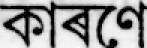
কাৰণে
